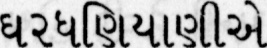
ઘરધણિયાણીએ
